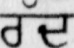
ਰੱਦ
